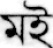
মই
